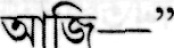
আজি-"
